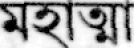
মহাত্মা
